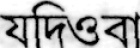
যদিওবা
